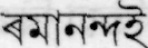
ৰমানন্দই
